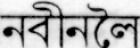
নবীনলৈ
